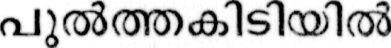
പുല്‍ത്തകിടിയില്‍
